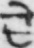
ਦੇ
